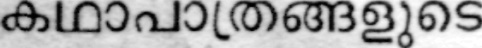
കഥാപാത്രങ്ങളുടെ
